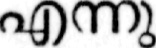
എന്നു
